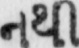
નથી
